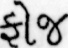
ફોજ
